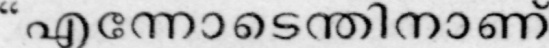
"എന്നോടെന്തിനാണ്
